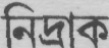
নিদ্ৰাক
